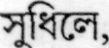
সুধিলে,
